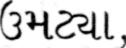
ઉમટ્યા,
